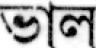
ভাল
